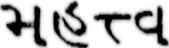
મહત્ત્વ
